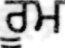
ਰੂਮ
